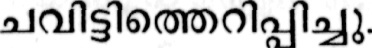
ചവിട്ടിത്തെറിപ്പിച്ചു.
